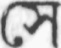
সে
